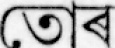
তোৰ
